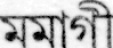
মমাগী
